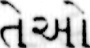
તેઓ
